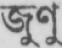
জুণু
